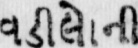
વડીલોની
